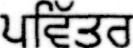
ਪਵਿੱਤਰ
